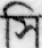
সি
